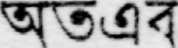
অতএব
